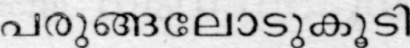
പരുങ്ങലോടുകൂടി
